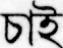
চাই
